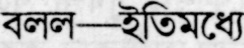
বলল–ইতিমধ্যে
